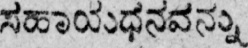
ಸಹಾಯಧನವನ್ನು
